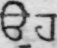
ਉਹ
